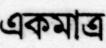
একমাত্র
